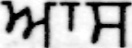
ਆਸ
